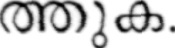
ത്തുക.
